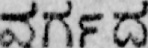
ವರ್ಗದ
